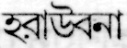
হরাউবনা
